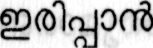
ഇരിപ്പാന്‍
